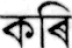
কৰি
